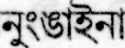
নুংঙাইনা
